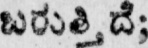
ಬರುತ್ತಿದೆ;
